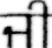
ਜੀ
